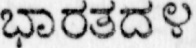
ಭಾರತದಳ
